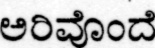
ಅರಿವೊಂದೆ
